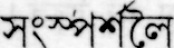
সংস্পৰ্শলৈ
